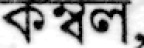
কম্বল,
